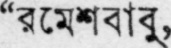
‘‘রমেশবাবু,
